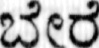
ಬೇರೆ
